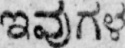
ಇವುಗಳ
